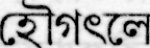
হৌগৎলে
